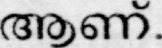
ആണ്.
